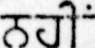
ਨਹੀਂ
